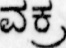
ವಕ್ರ
